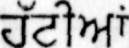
ਹੱਟੀਆਂ
